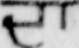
ਦਾ
